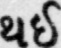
થઈ
